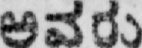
ಅವರು
